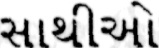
સાથીઓ
